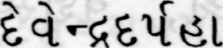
દેવેન્દ્રદર્પહા
